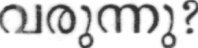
വരുന്നു?
